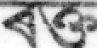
ৰক্ত
